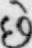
છે
